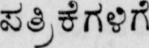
ಪತ್ರಿಕೆಗಳಿಗೆ
